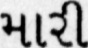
મારી
